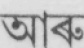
আৰু
